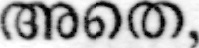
അതെ,
